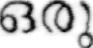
ഒരു
